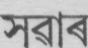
সৱাৰ
